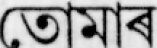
তোমাৰ
